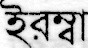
ইরম্বা
